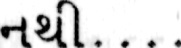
નથી....
